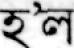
হ'ল
